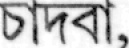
চাদবা,
